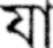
যা
